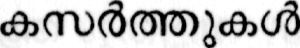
കസര്‍ത്തുകള്‍
